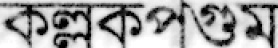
কল্লকপগুম
